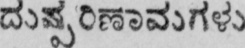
ದುಷ್ಪರಿಣಾಮಗಳು
